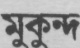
মুকুন্দ
